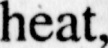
heat,
